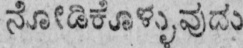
ನೋಡಿಕೊಳ್ಳುವುದು
